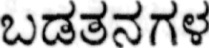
ಬಡತನಗಳ
